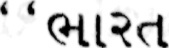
"ભારત
